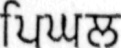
ਪਿਘਲ
